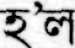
হ'ল
